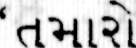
'તમારો
